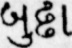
બુઢ્ઢા
